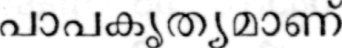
പാപകൃത്യമാണ്
